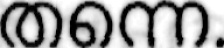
തന്നെ.
